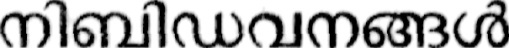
നിബിഡവനങ്ങള്‍
